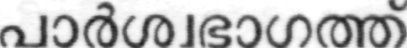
പാര്‍ശ്വഭാഗത്ത്
